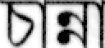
চান্না
